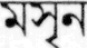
মসৃন
